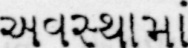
અવસ્થામાં
